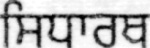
ਸਿਧਾਰਥ
